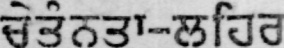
ਚੇਤੰਨਤਾ-ਲਹਿਰ
